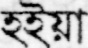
হইয়া
